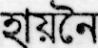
হায়নৈ
